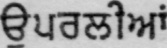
ਉਪਰਲੀਆਂ
